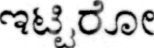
ಇಟ್ಟಿರೋ
